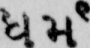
ધર્મ
